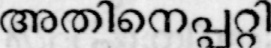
അതിനെപ്പറ്റി
